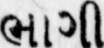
ભાગી
